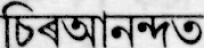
চিৰআনন্দত
